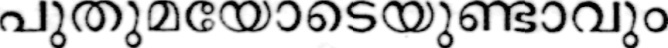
പുതുമയോടെയുണ്ടാവും
